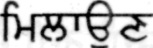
ਮਿਲਾਉਣ
